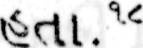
હતા.૧૮
